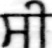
ਸੀ
